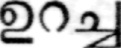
ഉറച്ച
